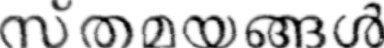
സ്തമയങ്ങള്‍
